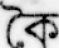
কৈ
